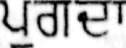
ਪੁਗਦਾ
